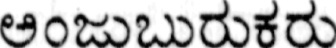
ಅಂಜುಬುರುಕರು
